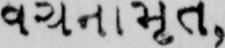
વચનામૃત,
